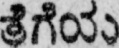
ತೆಗೆಯ
